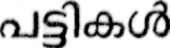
പട്ടികള്‍
